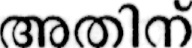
അതിന്
